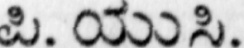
ಪಿ.ಯುಸಿ.
